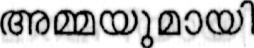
അമ്മയുമായി
